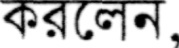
করলেন,
